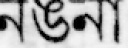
নঙনা
